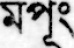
মপূং
